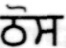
ਠੋਸ
